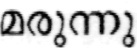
മരുന്നു
